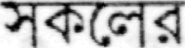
সকলের
